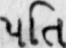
પતિ
